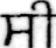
ਸੀ
